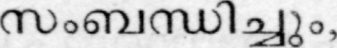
സംബന്ധിച്ചും,
